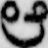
ಆ
